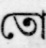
তো
